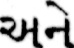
અને
